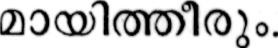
മായിത്തീരും.
